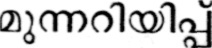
മുന്നറിയിപ്പ്
